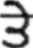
ਤੇ
